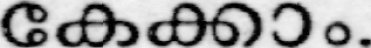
കേക്കാം.
